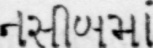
નસીબમાં
